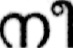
നീ
